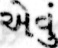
એવું
